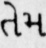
તેમ
